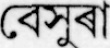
বেসুৰা
